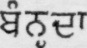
ਬੰਨ੍ਹਦਾ
